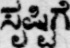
ಸೃಷ್ಟಿಗೆ
